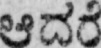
ಆದರೆ
